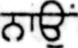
ਨਾਉਂ
